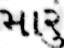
મારું
